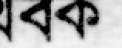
থবক
